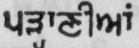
ਪੜ੍ਹਾਣੀਆਂ
